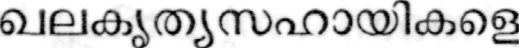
ഖലകൃത്യസഹായികളെ
